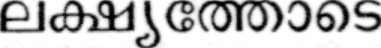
ലക്ഷ്യത്തോടെ
